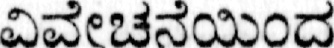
ವಿವೇಚನೆಯಿಂದ
